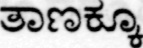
ತಾಣಕ್ಕೂ
